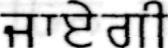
ਜਾਏਗੀ
